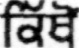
ਕਿੱਥੋਂ
